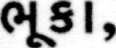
ભૂકા,
